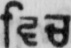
ਵਿਚ
